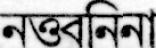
নত্তবনিনা
